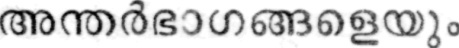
അന്തര്‍ഭാഗങ്ങളെയും
